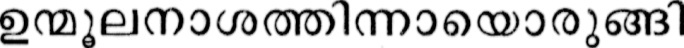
ഉന്മൂലനാശത്തിന്നായൊരുങ്ങി
